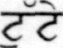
ਟੁੱਟੇ
